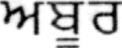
ਅਬੂਰ
